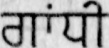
ਗਾਂਧੀ
